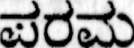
ಪರಮ
